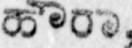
ಹೌರಾ,
